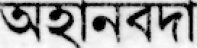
অহানবদা
